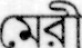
মেরী
